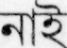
নাই
